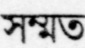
সম্মত
